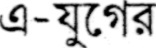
এ-যুগের
